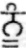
ਨੂੰ
